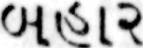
બહાર
